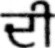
ਦੀ
